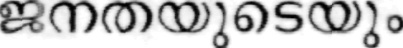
ജനതയുടെയും
